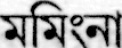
মমিংনা
